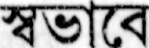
স্বভাবে
